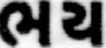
ભય
